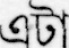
এটা
